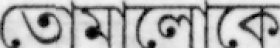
তোমালোকে
